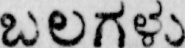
ಬಲಗಳು
